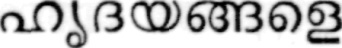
ഹൃദയങ്ങളെ
